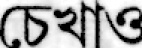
চেখাও
